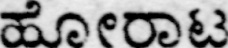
ಹೋರಾಟ
